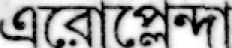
এরোপ্লেন্দা
